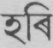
হৰি
